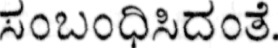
ಸಂಬಂಧಿಸಿದಂತೆ.
